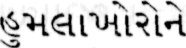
હુમલાખોરોને
